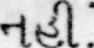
નહીં.
